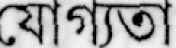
যোগ্যতা
